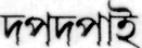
দপদপাই
